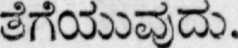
ತೆಗೆಯುವುದು.
